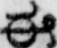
ಈ
